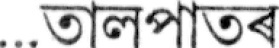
...তালপাতৰ
